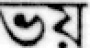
ভয়
